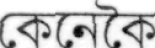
কেনেকৈ
